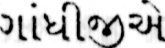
ગાંધીજીએ
